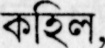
কহিল,
